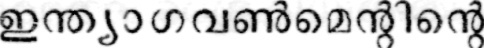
ഇന്ത്യാഗവണ്‍മെന്റിന്റെ
